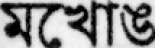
মখোঙ
